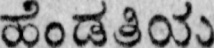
ಹೆಂಡತಿಯ
